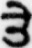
ਤੇ
